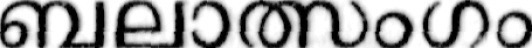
ബലാത്സംഗം
